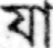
যা
